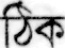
ঠিক
